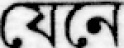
যেনে
